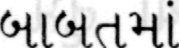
બાબતમાં
